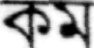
কম
